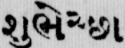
શુભેચ્છા
